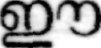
ഈ
